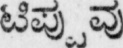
ಟಿಪ್ಪುವು
